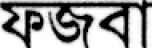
ফজবা
